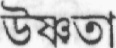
উষ্ণতা
